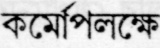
কর্মোপলক্ষে
